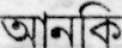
আনকি
